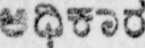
ಅಧಿಕಾರ
